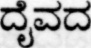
ದೈವದ
